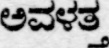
ಅವಳತ್ತ
